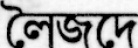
লৈজদে
